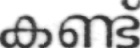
കണ്ട്
